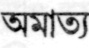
অমাত্য
